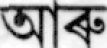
আৰু
